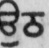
ਉਠ
